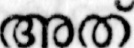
അത്
